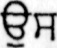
ਉਸ
